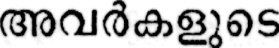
അവര്‍കളുടെ
